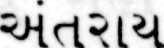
અંતરાય
